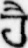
ਹੈ
